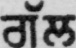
ਗੱਲ
